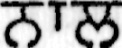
ਨਾਲ
